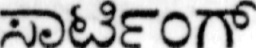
ಸಾರ್ಟಿಂಗ್
